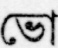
ভো
